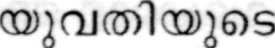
യുവതിയുടെ
